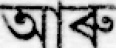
আৰু
